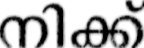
നിക്ക്
